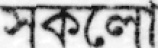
সকলো
